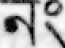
নং
